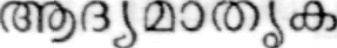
ആദ്യമാതൃക
